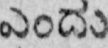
ಎಂದು
